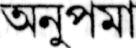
অনুপমা
